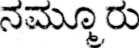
ನಮ್ಮೂರು
